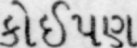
કોઈપણ
